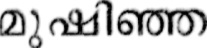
മുഷിഞ്ഞ
